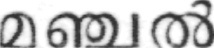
മഞ്ചല്‍
